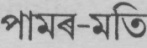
পামৰ-মতি
